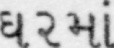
ઘરમાં
